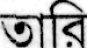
তারি
